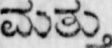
ಮತ್ತು
